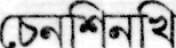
চেনশিনখি
